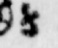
છીએ.છેક
